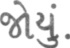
જોયું.
